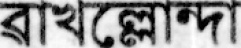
ৱাখল্লোন্দা
